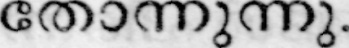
തോന്നുന്നു.
